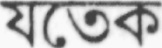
যতেক
